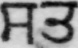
ਸਤ
